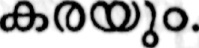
കരയും.
